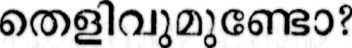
തെളിവുമുണ്ടോ?
